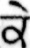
ਕੇ
